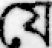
যে
